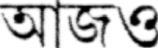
আজও
